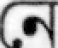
নে
